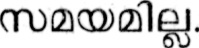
സമയമില്ല.
